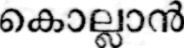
കൊല്ലാന്‍
